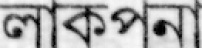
লাকপনা
